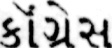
કૉંગ્રેસ
